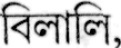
বিলালি,
